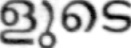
ളുടെ
